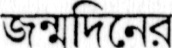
জন্মদিনের
